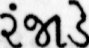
રંજાડે
